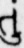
તું
